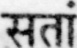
सतां
